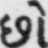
છો
